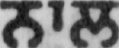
ਨਾਲ
